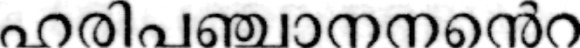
ഹരിപഞ്ചാനനന്റെ
